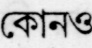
কোনও
